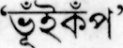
'ভূঁইকঁপ'
